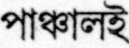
পাঞ্চালই
